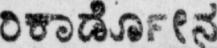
ರಿಕಾರ್ಡೋನ
